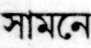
সামনে
